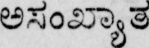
ಅಸಂಖ್ಯಾತ
